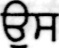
ਉਸ
